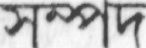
সম্পদ
